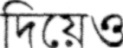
দিয়েও
